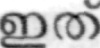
ഇത്
